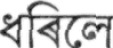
ধৰিলে
